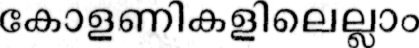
കോളണികളിലെല്ലാം
